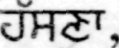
ਹੱਸਣਾ,
